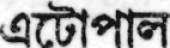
এটোপাল
